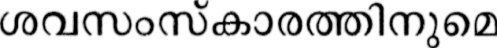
ശവസംസ്കാരത്തിനുമെ
